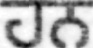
ਹਨ
